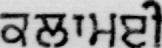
ਕਲਾਮਈ
